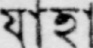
যাহা
